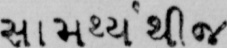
સામર્થ્યથીજ
